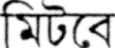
মিটবে
